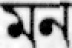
মন
